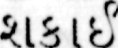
શકાઈ
